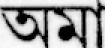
অমা
